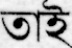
তাই
